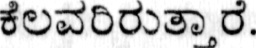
ಕೆಲವರಿರುತ್ತಾರೆ.
